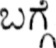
ಬಗ್ಗೆ
